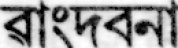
ৱাংদবনা
